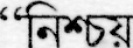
"নিশ্চয়
